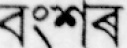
বংশৰ
